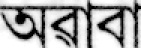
অৱাবা
